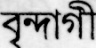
বৃন্দাগী
